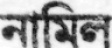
নামিল
